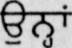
ਉਨ੍ਹਾਂ
